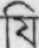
যি
